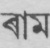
ৰাম
